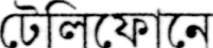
টেলিফোনে
